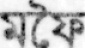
মফৈ
